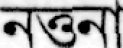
নত্তনা
